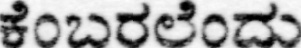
ಕೆಂಬರಲೆಂದು
